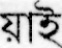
য়াই
